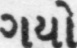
ગયો
